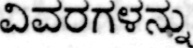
ವಿವರಗಳನ್ನು
